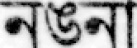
নঙনা
